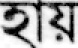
হায়
